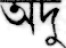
অদু
